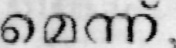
മെന്ന്,
